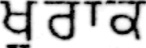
ਖੁਰਾਕ
